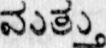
ಮತ್ತು
